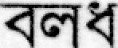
বলধ
